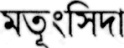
মতূংসিদা
